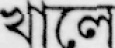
খালে
